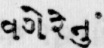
વગેરેનું
